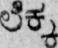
ಲೆಕ್ಕ
